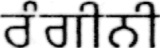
ਰੰਗੀਨੀ
